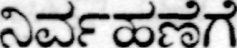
ನಿರ್ವಹಣೆಗೆ
